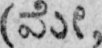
(ಮೇ,
